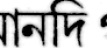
মানদি
